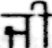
ਜੀ
